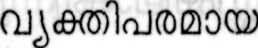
വ്യക്തിപരമായ
